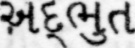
અદભુત
